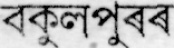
বকুলপুৰৰ
